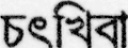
চৎখিবা
